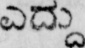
ಎದ್ದು
